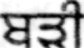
ਬੜੀ
